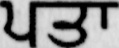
ਪਤਾ
